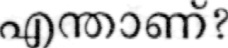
എന്താണ്?
